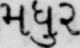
મધુર
